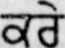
ਕਰੇ
